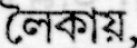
লৈকায়,
